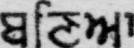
ਬਣਿਆ
